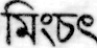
মিংচৎ
